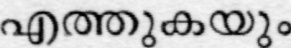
എത്തുകയും
